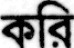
করি
